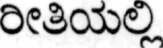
ರೀತಿಯಲ್ಲಿ
